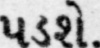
પડશે.
